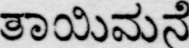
ತಾಯಿಮನೆ
